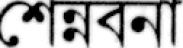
শেন্নবনা
